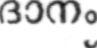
ദാനം
